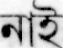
নাই
